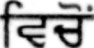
ਵਿਚੋਂ
